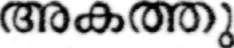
അകത്തു
